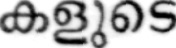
കളുടെ
